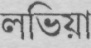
লভিয়া
